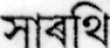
সাৰথি
